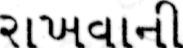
રાખવાની
